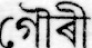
গৌৰী
